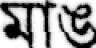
মাঙ
